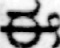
ಈ
